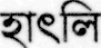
হাৎলি
